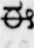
ಈ
